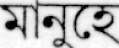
মানুহে
